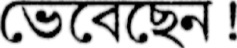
ভেবেছেন!
